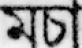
মচা
